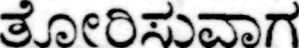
ತೋರಿಸುವಾಗ
